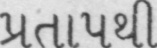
પ્રતાપથી
